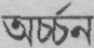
অৰ্চ্চন
